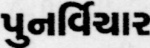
પુનર્વિચાર
